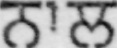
ਨਾਲ
